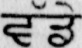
ਵੱਡੇ
